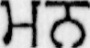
ਮਨ
